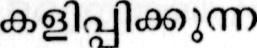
കളിപ്പിക്കുന്ന
